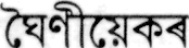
ঘৈণীয়েকৰ
